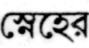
স্নেহের
